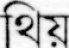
থিয়
